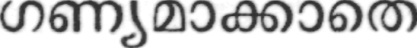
ഗണ്യമാക്കാതെ
